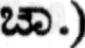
ಚಾ.)
